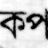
কপ
